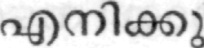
എനിക്കു
